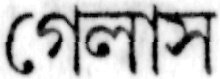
গেলাস
